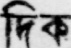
দিক
